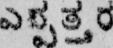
ಎಪ್ಪತ್ತರ
